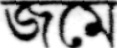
জমে
